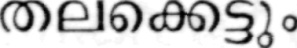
തലക്കെട്ടും
